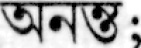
অনন্ত;
